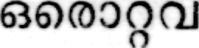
ഒരൊറ്റവ
